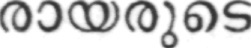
രായരുടെ
